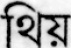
থিয়
